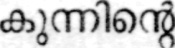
കുന്നിന്റെ
